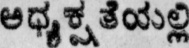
ಅಧ್ಯಕ್ಷತೆಯಲ್ಲಿ
